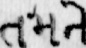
તમને
